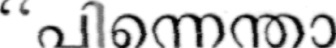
"പിന്നെന്താ
